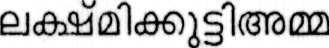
ലക്ഷ്മിക്കുട്ടിഅമ്മ
